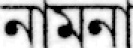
নামনা
